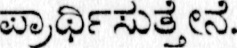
ಪ್ರಾರ್ಥಿಸುತ್ತೇನೆ.
